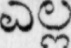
ಎಲ್ಲ
